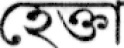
হেক্তা
